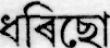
ধৰিছো
